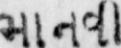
માનવી
